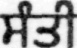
ਸੰਤੀ
